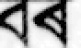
বৰ
